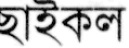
ছাইকল
